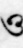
ও
